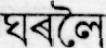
ঘৰলৈ
